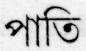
পাতি
